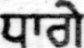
ਧਾਗੇ
